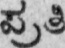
ಪ್ರತಿ
